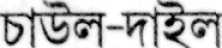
চাউল-দাইল
